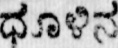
ಧೂಳಿನ
